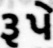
રૂપે
